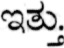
ಇತ್ತು.
